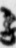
કોલેજ-વિધાર્થી
